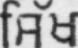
ਸਿੱਖ
